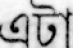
এটা
